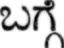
ಬಗ್ಗೆ
